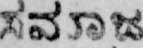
ಸಮಾಜ
